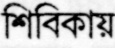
শিবিকায়
